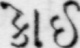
કોઈ
